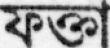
ফক্তা
